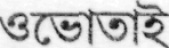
ওভোতাই
